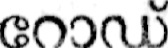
റോഡ്
